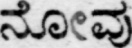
ನೋವು
